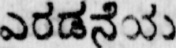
ಎರಡನೆಯ
